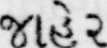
જાહેર
